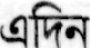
এদিন
